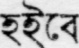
হইবে
